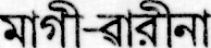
মাগী-ৱারীনা
